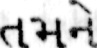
તમને
